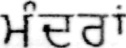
ਮੰਦਰਾਂ
